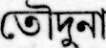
তৌদুনা
